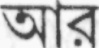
আর
